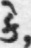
કે,
